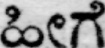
ಹೀಗೆ
